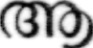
ആ
